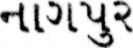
નાગપુર
